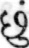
છું
